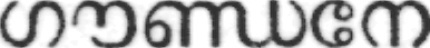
ഗൗണ്ഡനേ
